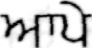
ਆਪੇ
